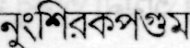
নুংশিরকপগুম
